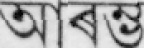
আৰম্ভ
